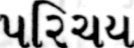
પરિચય
